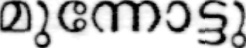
മുന്നോട്ടു
